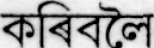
কৰিবলৈ
